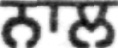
ਨਾਲ
